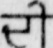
ਦੀ
